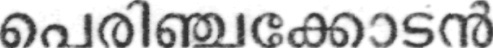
പെരിഞ്ചക്കോടന്‍
